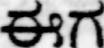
ಈಗ
